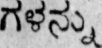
ಗಳನ್ನು
